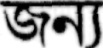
জন্য
